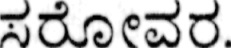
ಸರೋವರ.
